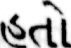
હતો
